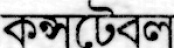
কন্সটেবল
